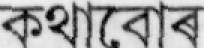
কথাবোৰ
